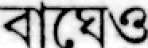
বাঘেও
